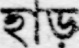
হাড়
